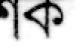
শক
